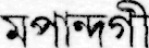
মপান্দগী
